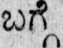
ಬಗ್ಗೆ
